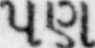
પણ
